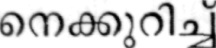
നെക്കുറിച്ച്
